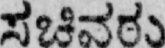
ಸಚಿವರು
